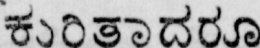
ಕುರಿತಾದರೂ
